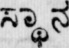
ಸ್ಥಾನ
